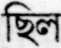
ছিল
